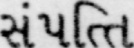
સંપત્તિ
